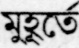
মুহূর্তে
